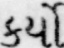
કર્યો
